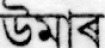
উমাৰ
